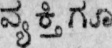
ವ್ಯಕ್ತಿಗೂ
